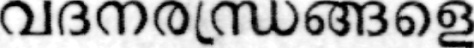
വദനരന്ധ്രങ്ങളെ
